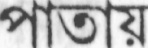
পাতায়
